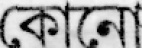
কোনো
